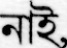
নাই,
